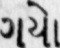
ગયો
